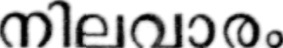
നിലവാരം
